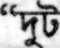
“দুট
